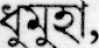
ধুমুহা,
